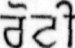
ਰੋਟੀ
